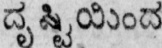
ದೃಷ್ಟಿಯಿಂದ
